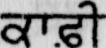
ਕਾਫ਼ੀ
